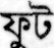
ফুট
